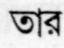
তার
